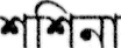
শশিনা
